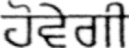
ਹੋਵੇਗੀ
